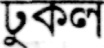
ঢুকল
